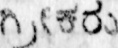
ಗ್ರೀಕರು
